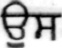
ਉਸ
